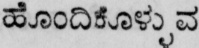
ಹೊಂದಿಕೊಳ್ಳುವ
